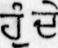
ਹੁੰਦੇ
